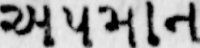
અપમાન
